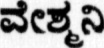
ವೇಶ್ಮನಿ
